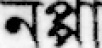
নপ্পা
